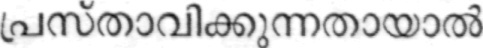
പ്രസ്താവിക്കുന്നതായാല്‍
